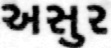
અસુર
